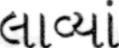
લાવ્યાં
